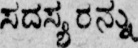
ಸದಸ್ಯರನ್ನು
